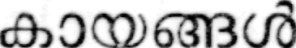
കായങ്ങള്‍
